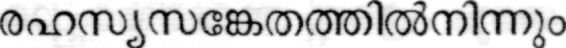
രഹസ്യസങ്കേതത്തില്‍നിന്നും
